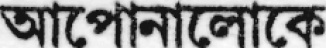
আপোনালোকে
